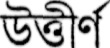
উত্তীর্ণ
